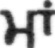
ਮਾਂ
